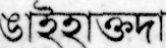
ঙাইহাক্তদা
